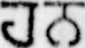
ਹਨ
